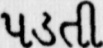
પડતી
